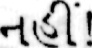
નહીં!
